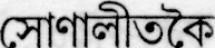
সোণালীতকৈ
